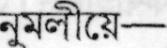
নুমলীয়ে-
